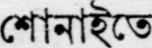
শোনাইতে
